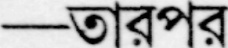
–তারপর
